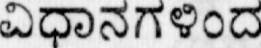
ವಿಧಾನಗಳಿಂದ
